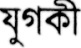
যুগকী
